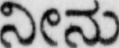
ನೀನು
